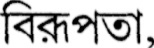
বিরূপতা,
